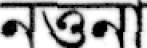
নত্তনা
